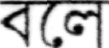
বলে
